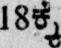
18ಕ್ಕೆ
